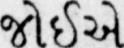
જોઈએ
